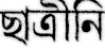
ছাত্রীনি
